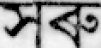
সৰু
